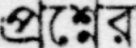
প্রশ্নের
